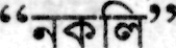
“নকলি”
